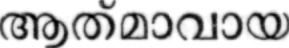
ആത്മാവായ
